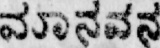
ಮಾನವನ
